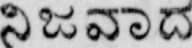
ನಿಜವಾದ
